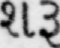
શરૂ
